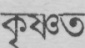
কৃষ্ণত
